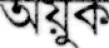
অয়ুক
